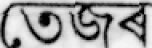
তেজৰ
